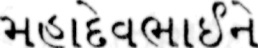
મહાદેવભાઈને
